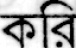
করি
